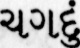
ચગદું
